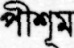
পীশূম
